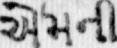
એમની
